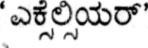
'ಎಕ್ಸೆಲ್ಸಿಯರ್'
